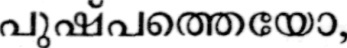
പുഷ്പത്തെയോ,
